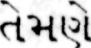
તેમણે
